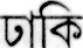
ঢাকি
